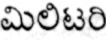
ಮಿಲಿಟರಿ
